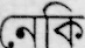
নেকি
